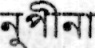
নুপীনা
